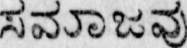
ಸಮಾಜವು
